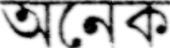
অনেক
